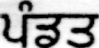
ਪੰਡਤ
